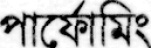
পার্ফোমিং
